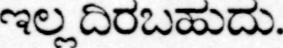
ಇಲ್ಲದಿರಬಹುದು.
